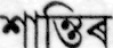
শান্তিৰ
